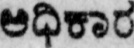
ಅಧಿಕಾರ
